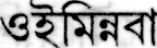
ওইমিন্নবা
